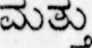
ಮತ್ತು
